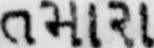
તમારા
